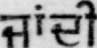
ਜਾਂਦੀ
